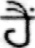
ਹੈਂ
